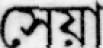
সেয়া
